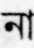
না
